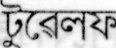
টুৱেলফ
